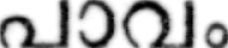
പാവം
